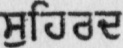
ਸੁਹਿਰਦ
